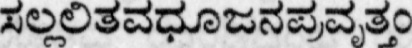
ಸಲ್ಲಲಿತವಧೂಜನಪ್ರವೃತ್ತಂ
